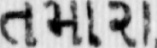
તામારા
